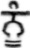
ਨੂੰ
